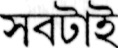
সবটাই
